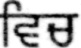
ਵਿਚ
